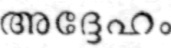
അദ്ദേഹം
